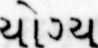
યોગ્ય
